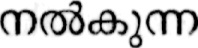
നല്‍കുന്ന
